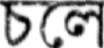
চলে
